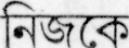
নিজকে
